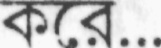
করে...
